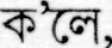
ক'লে,
